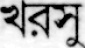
খরসু
